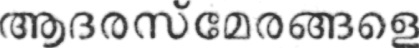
ആദരസ്മേരങ്ങളെ
